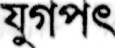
যুগপৎ
